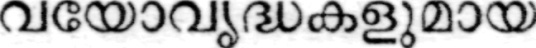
വയോവൃദ്ധകളുമായ
